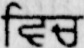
ਵਿਚ
